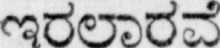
ಇರಲಾರವೆ
